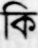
কি
